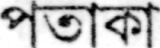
পতাকা
